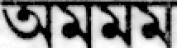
অমমম
